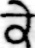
ਕੇ
